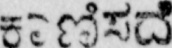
ಕಾಣಿಸದೆ
